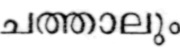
ചത്താലും
